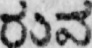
ರುವ
